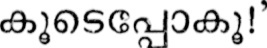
കൂടെപ്പോകൂ!'
